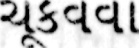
ચૂકવવા
